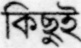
কিছুই
